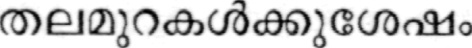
തലമുറകള്‍ക്കുശേഷം
